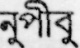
নুপীবু
